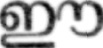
ഈ
